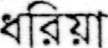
ধরিয়া
